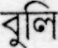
বুলি
